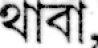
থাবা,
